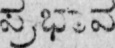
ಪ್ರಭಾವ
